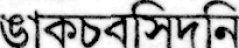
ঙাকচবসিদনি
